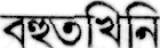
বহুতখিনি
